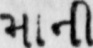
માની
